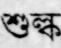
শুল্ক
